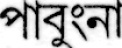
পাবুংনা
